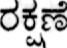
ರಕ್ಷಣೆ
